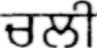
ਚਲੀ
